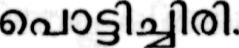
പൊട്ടിച്ചിരി.
